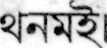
থনমই।
